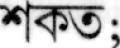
শকত;
